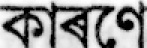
কাৰণে
